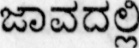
ಜಾವದಲ್ಲಿ
